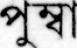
পুম্বা
